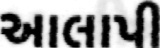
આલાપી
